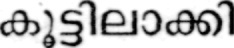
കൂട്ടിലാക്കി
